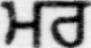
ਮਰ
